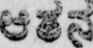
ಆತನ
